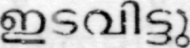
ഇടവിട്ടു
